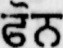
ਫੋਨ
